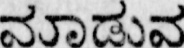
ಮಾಡುವ
